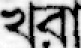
খরা
